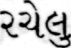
રચેલું
